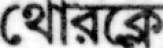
থোরক্লে
